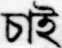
চাই
